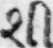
શી
